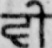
ਵੀ
